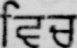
ਵਿਚ
